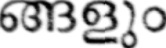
ങ്ങളും
